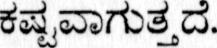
ಕಷ್ಟವಾಗುತ್ತದೆ.
